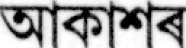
আকাশৰ
